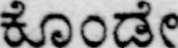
ಕೊಂಡೇ
